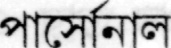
পার্সোনাল
